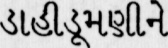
ડાહીડૂમણીને
